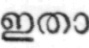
ഇതാ
